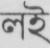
লই
